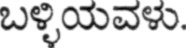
ಬಳ್ಳಿಯವಳು.
